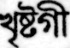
খৃষ্টগী
